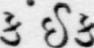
કંઈક
